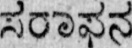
ಸರಾಫನ
